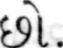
છો.
